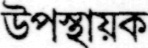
উপস্থায়ক
